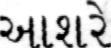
આશરે
